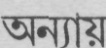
অন্যায়
